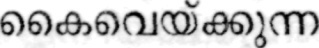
കൈവെയ്ക്കുന്ന
